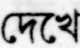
দেখে
